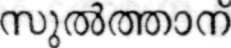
സുല്‍ത്താന്
